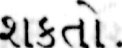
શકતો.
